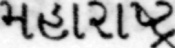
મહારાષ્ટ્ર
